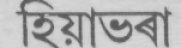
হিয়াভৰা
